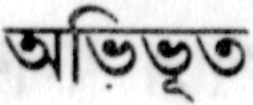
অভিভূত
